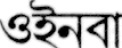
ওইনবা
